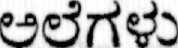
ಅಲೆಗಳು
